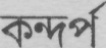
কন্দৰ্প
